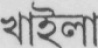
খাইলা
